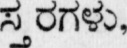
ಸ್ತರಗಳು,
